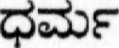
ಧರ್ಮ
